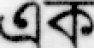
এক
